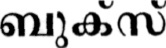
ബുക്സ്
